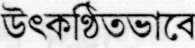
উত্কণ্ঠিতভাবে
